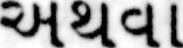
અથવા
